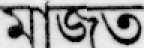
মাজত
